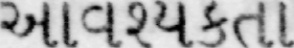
આવશ્યકતા
